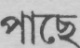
পাছে
